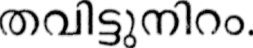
തവിട്ടുനിറം.
